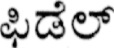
ಫಿಡೆಲ್
